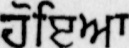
ਹੋਇਆ
